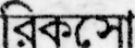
রিকসো
